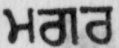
ਮਗਰ
